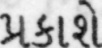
પ્રકાશે
